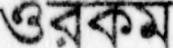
ওরকম
